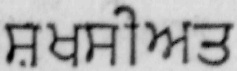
ਸ਼ਖਸੀਅਤ
